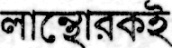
লান্থোরকই
